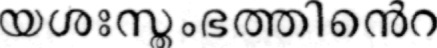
യശഃസ്തംഭത്തിന്റെ
